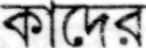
কাদের
